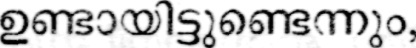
ഉണ്ടായിട്ടുണ്ടെന്നും,
